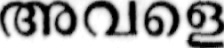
അവളെ
